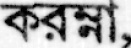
করম্না,
